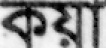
কয়া
